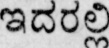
ಇದರಲ್ಲಿ
